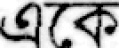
একে
